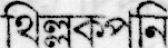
থিল্লকপনি
